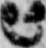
ಆ
